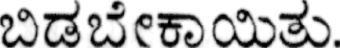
ಬಿಡಬೇಕಾಯಿತು.
